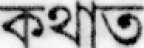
কথাত
